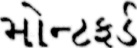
મોન્ટફર્ડ
